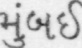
મુંબઈ
